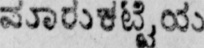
ಮಾರುಕಟ್ಟೆಯ
